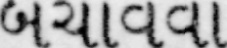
બચાવવા
